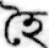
হৈ
